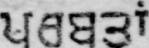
ਪਰਬਤਾਂ
